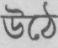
উঠে
